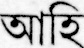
আহি
